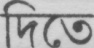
দিতে
